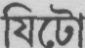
যিটো
